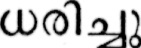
ധരിച്ചു
